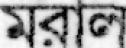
মরাল
